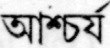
আশ্চর্য
